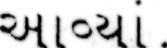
આવ્યાં.
